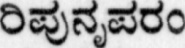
ರಿಪುನೃಪರಂ
